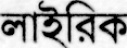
লাইরিক
